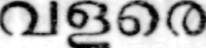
വളരെ
